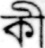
কী
